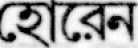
হোরেন
